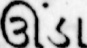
ઊંડા
